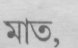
মাত,
